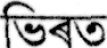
ভিৰত
